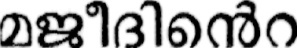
മജീദിന്റെ
